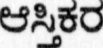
ಆಸ್ತಿಕರ
